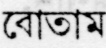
বোতাম
